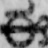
ಈ
